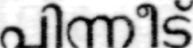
പിന്നീട്
